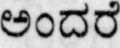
ಅಂದರೆ
